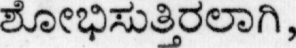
ಶೋಭಿಸುತ್ತಿರಲಾಗಿ,
